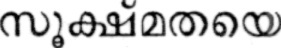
സൂക്ഷ്മതയെ
